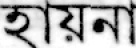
হায়না
